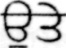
ਉਤੇ
